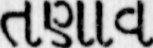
તણાવ
